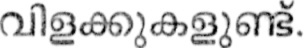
വിളക്കുകളുണ്ട്.
